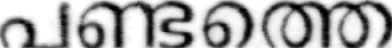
പണ്ടത്തെ
